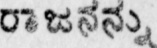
ರಾಜನನ್ನು
